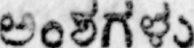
ಅಂಶಗಳು
